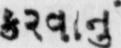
કરવાનું
